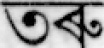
তৰু
